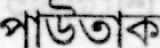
পাউতাক
